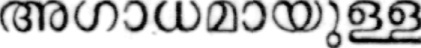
അഗാധമായുള്ള
